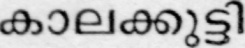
കാലക്കുട്ടി
